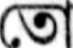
তো
